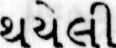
થયેલી
